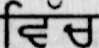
ਵਿੱਚ
